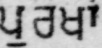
ਪੁਰਖਾਂ
